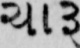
ચારૂ
